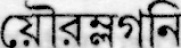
য়ৌরম্লগনি
